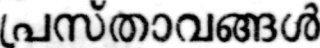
പ്രസ്താവങ്ങള്‍
